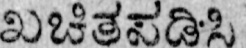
ಖಚಿತಪಡಿಸಿ
